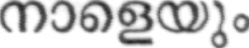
നാളെയും
